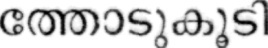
ത്തോടുകൂടി
